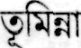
তূমিন্না
